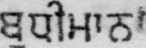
ਬੁਧੀਮਾਨਾ
